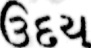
ઉદય
